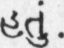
હતું.
